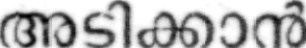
അടിക്കാന്‍
